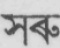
সৰু
